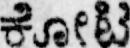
ಕೋಟಿ
